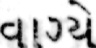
વાગ્યે
